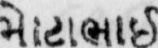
મોટાભાઈ
